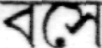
বসে
